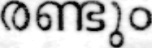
രണ്ടും
